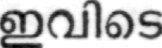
ഇവിടെ
